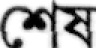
শেষ
